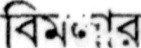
বিমলার
